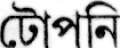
টোপনি
